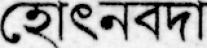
হোৎনবদা
